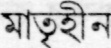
মাতৃহীন
